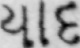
યાદ
